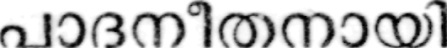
പാദനീതനായി
